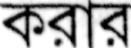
করার
